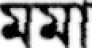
মমা
